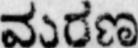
ಮರಣ
